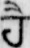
ਹੈ
